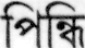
পিন্ধি
